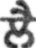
ਲੈ
